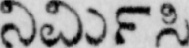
ನಿರ್ಮಿಸಿ
